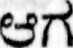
ಆಗ
